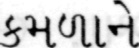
કમળાને
